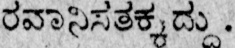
ರವಾನಿಸತಕ್ಕದ್ದು.
